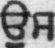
ਉਸ
